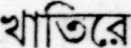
খাতিরে
